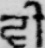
ਵੀ
